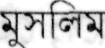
মুসলিম
